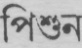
পিশুন
